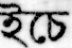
ইচে
